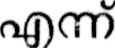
എന്ന്
